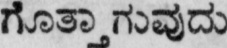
ಗೊತ್ತಾಗುವುದು
